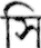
সি
